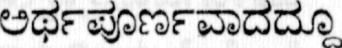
ಅರ್ಥಪೂರ್ಣವಾದದ್ದೂ
